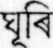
ঘূৰি
